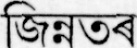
জিন্নতৰ
